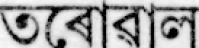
তৰোৱাল
